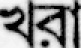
খরা
